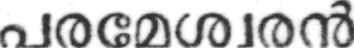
പരമേശ്വരന്‍
